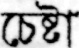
চেষ্টা
